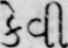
કેવી
